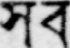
সব
